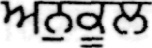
ਅਨੁਕੂਲ
